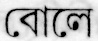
বোলে
